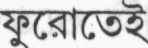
ফুরোতেই
